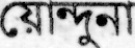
য়োন্দুনা
